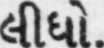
લીધો.
